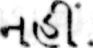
નહીં.
